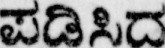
ಪಡಿಸಿದ
